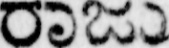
ರಾಜು
